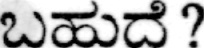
ಬಹುದೆ?
